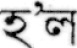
হ'ল
